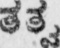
ತತ್ವ
